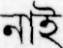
নাই
